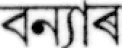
বন্যাৰ
